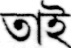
তাই
